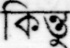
কিন্তু
